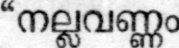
"നല്ലവണ്ണം
